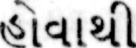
હોવાથી
